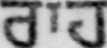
ਰਾਹ
